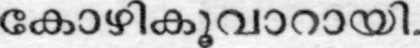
കോഴികൂവാറായി.
